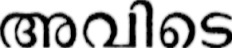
അവിടെ
